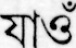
যাওঁ
